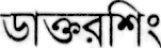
ডাক্তরশিং
